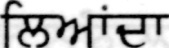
ਲਿਆਂਦਾ
